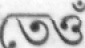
তেওঁ
